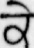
ਕੇ
